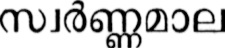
സ്വര്‍ണ്ണമാല
